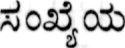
ಸಂಖ್ಯೆಯ
